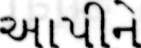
આપીને
